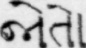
જોતો
